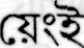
য়েংই
